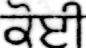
ਕੋਈ
